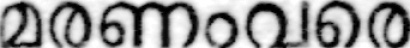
മരണംവരെ
